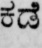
ಕಡೆ
